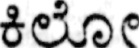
ಕಿಲೋ
